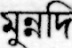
মুন্নদি
